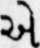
એ
